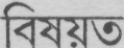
বিষয়ত
